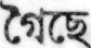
গৈছে
